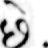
છે.
